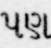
પણ
